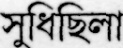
সুধিছিলা
